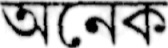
অনেক
